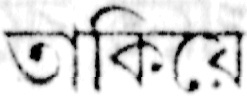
একটু
